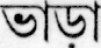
ভাড়া
